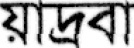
য়াদ্রবা
